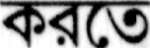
করতে
